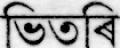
ভিতৰি
